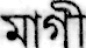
মাগী
